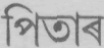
পিতাৰ
